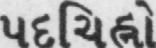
પદચિહ્નો
